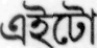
এইটো
